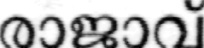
രാജാവ്
